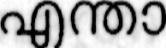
എന്താ
